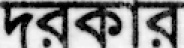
দরকার
